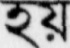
হয়
